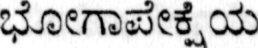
ಭೋಗಾಪೇಕ್ಷೆಯ
